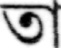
তা
